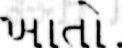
ખાતો.
